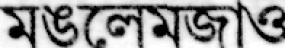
মঙলেমজাও
